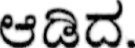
ಆಡಿದ.
